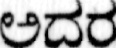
ಅದರ
